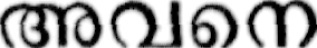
അവനെ
